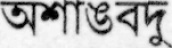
অশাঙবদু
